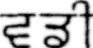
ਵਡੀ
